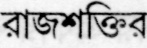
রাজশক্তির
